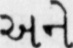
અને
